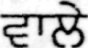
ਵਾਲੇ
